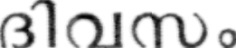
ദിവസം
